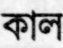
কাল
